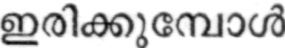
ഇരിക്കുമ്പോള്‍
